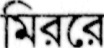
মিররে
